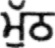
ਮੁੱਠ
